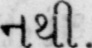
નથી.
